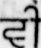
ਵੀ
